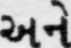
અને
